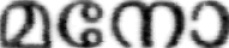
മനോ
